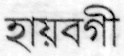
হায়বগী
